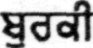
ਬੁਰਕੀ
